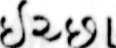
ઇચ્છા
